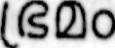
ഭ്രമം
